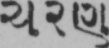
ચરણ
